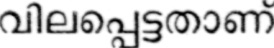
വിലപ്പെട്ടതാണ്
